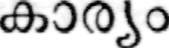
കാര്യം
